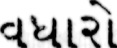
વધારો
